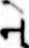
ને
